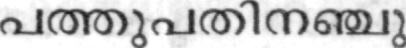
പത്തുപതിനഞ്ചു
